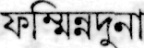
ফম্মিন্নদুনা
